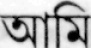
আমি
